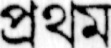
প্রথম
